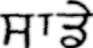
ਸਾਡੇ
